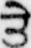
ਤੇ
